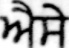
ਐਸੇ
